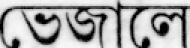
ভেজালে
